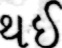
થઈ
